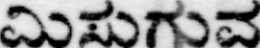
ಮಿಸುಗುವ
